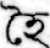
হৈ
